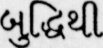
બુદ્ધિથી
